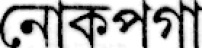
নোকপগা
